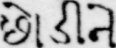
છોડીને
